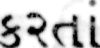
કરતાં
